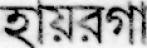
হায়রগা
